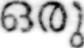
ഒരു
